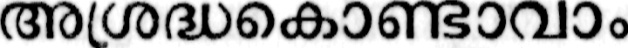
അശ്രദ്ധകൊണ്ടാവാം
